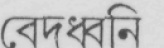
বেদধ্বনি
